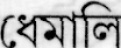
ধেমালি
